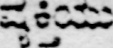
ವ್ಯಕ್ತಿಯು
